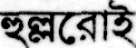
হুল্লরোই
